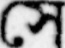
সে
